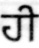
ਹੀ
